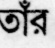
তাঁর
